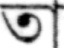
তা
